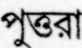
পুত্তরা
